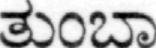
ತುಂಬಾ
